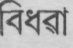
বিধৱা
